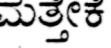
ಮತ್ತೇಕೆ
